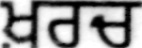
ਖ਼ਰਚ
